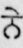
ਨੇ
